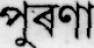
পুৰণা
